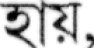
হায়,
